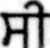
ਸੀ
